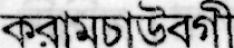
করামচাউবগী
